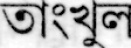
তাংখুল
